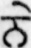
ਨੇ
